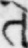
તે
